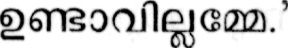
ഉണ്ടാവില്ലമ്മേ.’
